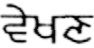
ਵੇਖਣ
